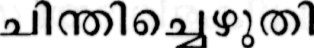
ചിന്തിച്ചെഴുതി
